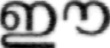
ഈ
